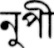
নুপী
